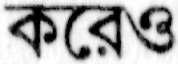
করেও
